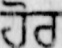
ਹੋਰ
